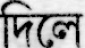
দিলে
